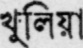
খুলিয়া
